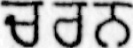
ਚਰਨ
